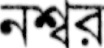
নশ্বর
